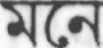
মনে
